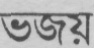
ভজয়
